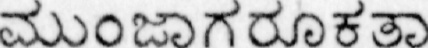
ಮುಂಜಾಗರೂಕತಾ
